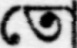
তো
